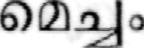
മെച്ചം
